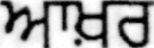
ਆਖ਼ਰ
